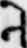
ને
